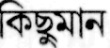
কিছুমান
